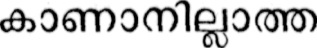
കാണാനില്ലാത്ത
